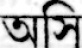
অসি
